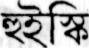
হুইস্কি
